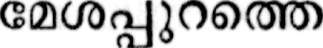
മേശപ്പുറത്തെ
